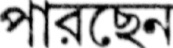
পারছেন
